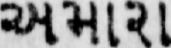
અમારા
